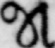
જા
